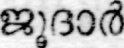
ജൂദാര്‍
